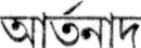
আর্তনাদ
